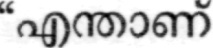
“എന്താണ്
